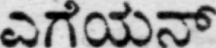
ಎಗೆಯನ್
